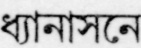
ধ্যানাসনে
